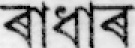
ৰাধাৰ
